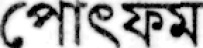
পোৎফম
